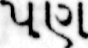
પણ
